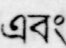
এবং
